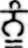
ਨੂੰ
